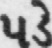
પડે
